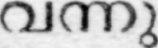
വന്നു
